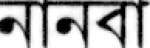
নানবা
